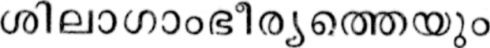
ശിലാഗാംഭീര്യത്തെയും
